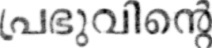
പ്രഭുവിന്റെ
